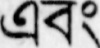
এবং
